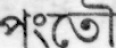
পংতৌ
